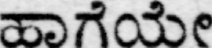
ಹಾಗೆಯೇ
